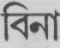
বিনা
